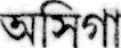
অসিগা
